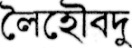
লৈহোবদু
